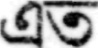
এত
